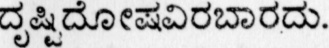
ದೃಷ್ಟಿದೋಷವಿರಬಾರದು.
